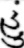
હું
